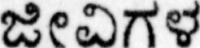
ಜೀವಿಗಳ
